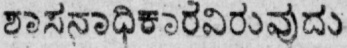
ಶಾಸನಾಧಿಕಾರವಿರುವುದು
